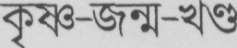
কৃষ্ণ-জন্ম-খণ্ড
